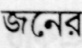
জনের
